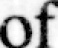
of
